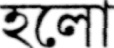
হলো
